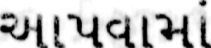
આપવામાં
